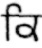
ਕਿ
